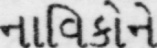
નાવિકોને
